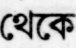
থেকে
